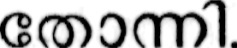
തോന്നി.
